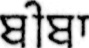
ਬੀਬਾ
